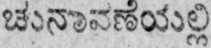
ಚುನಾವಣೆಯಲ್ಲಿ
